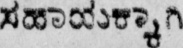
ಸಹಾಯಕ್ಕಾಗಿ
